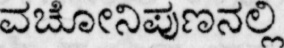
ವಚೋನಿಪುಣನಲ್ಲಿ
